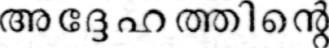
അദ്ദേഹത്തിന്റെ
